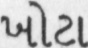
ખોટા
